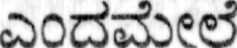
ಎಂದಮೇಲೆ
